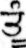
ਤੂੰ
